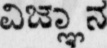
ವಿಜ್ಞಾನ
